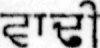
ਵਾਢੀ
